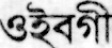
ওইবগী
